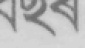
বছৰ
